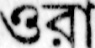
ওরা
